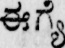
ಈಗ್ಯೆ
